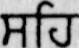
ਸਹਿ
